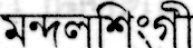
মন্দলশিংগী
